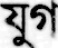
যুগ
